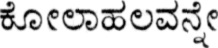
ಕೋಲಾಹಲವನ್ನೇ
